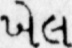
ખેલ
